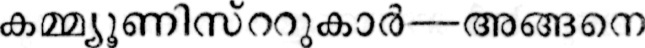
കമ്മ്യൂണ്ററുകാര്‍-അങ്ങനെ
